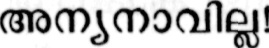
അന്യനാവില്ല!
